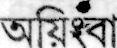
অয়িংবা
